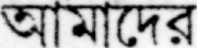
আমাদের
